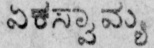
ಏಕಸ್ವಾಮ್ಯ
